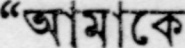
‘‘আমাকে
